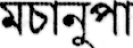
মচানুপা
